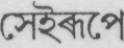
সেইৰূপে
